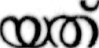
യത്
